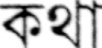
কথা
